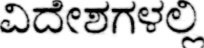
ವಿದೇಶಗಳಲ್ಲಿ
